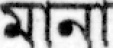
মানা
